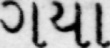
ગયા
